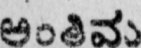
ಅಂತಿಮ
